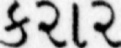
કરાર
